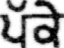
ਪੱਕੇ
